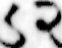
ડર
